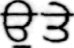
ਉਤੇ
